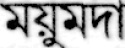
ময়ুমদা
